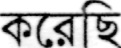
করেছি
